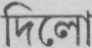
দিলো
